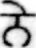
ਨੇ
